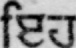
ਇਹ
